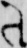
તે
